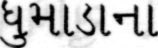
ધુમાડાના
